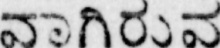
ವಾಗಿರುವ
